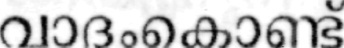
വാദംകൊണ്ട്
